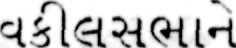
વકીલસભાને
